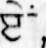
ਏਂ,
